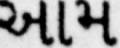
આમ
